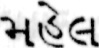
મહેલ
